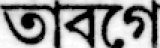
তাবগে
